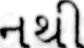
નથી
